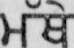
ਮੱਥੇ
